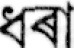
ধৰা
